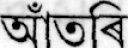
আঁতৰি
